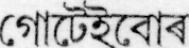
গোটেইবোৰ
